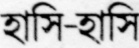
হাসি-হাসি
